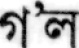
গ'ল
